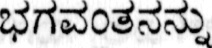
ಭಗವಂತನನ್ನು
